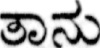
ತಾನು
